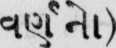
વર્ણનો)
